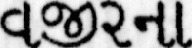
વજીરના
